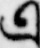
এ
